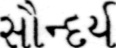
સૌન્દર્ય
